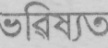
ভৱিষ্যত
